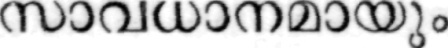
സാവധാനമായും
